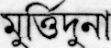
মুর্ত্তিদুনা
